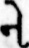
ને
